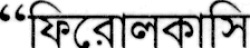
“ফিরোলকাসি
